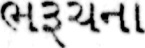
ભરૂચના
